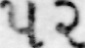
પર
